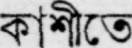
কাশীতে
